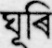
ঘূৰি
